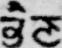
ਭੈਣ
